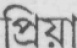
প্ৰিয়া
